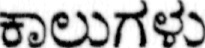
ಕಾಲುಗಳು
